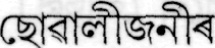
ছোৱালীজনীৰ
